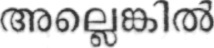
അല്ലെങ്കില്‍
